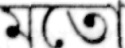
মতো
